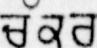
ਚੱਕਰ
